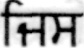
ਜਿਸ
